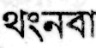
থংনবা
